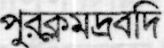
পুরক্লমদ্রবিদ
